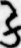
કે
